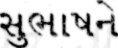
સુભાષને
